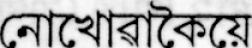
নোখোৱাকৈয়ে
